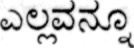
ಎಲ್ಲವನ್ನೂ
